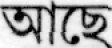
আছে
